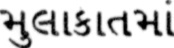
મુલાકાતમાં
